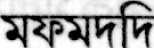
মফমদদি
